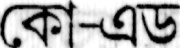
কো-এড
